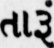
તારૂં
